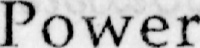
Power
